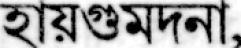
হায়গুমদনা,
